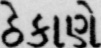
ઠેકાણે
